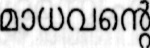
മാധവന്റെ
